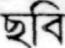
ছবি
